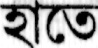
হাতে
